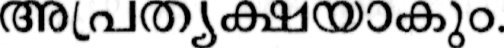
അപ്രത്യക്ഷയാകും.
